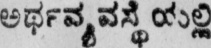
ಅರ್ಥವ್ಯವಸ್ಥೆಯಲ್ಲಿ
